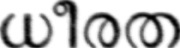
ധീരത
